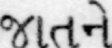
જાતને
